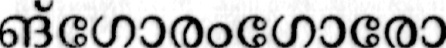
ങ്ഗോരംഗോരോ
